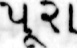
પૂરા
